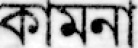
কামনা
